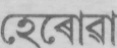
হেৰোৱা
